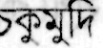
চকুমুদি
